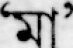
'মা'
